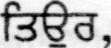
ਤਿਉਰ,
